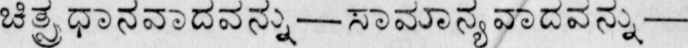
ಚಿತ್ಪ್ರಧಾನವಾದವನ್ನು-ಸಾಮಾನ್ಯವಾದವನ್ನು-
